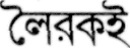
লৈরকই
